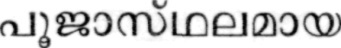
പൂജാസ്ഥലമായ
